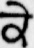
ਕੇ
